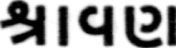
શ્રાવણ
